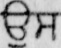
ਉਸ
